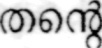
തന്റെ
